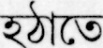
হঠাতে
